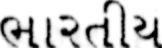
ભારતીય
